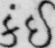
કંઈ
